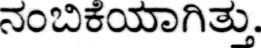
ನಂಬಿಕೆಯಾಗಿತ್ತು.
